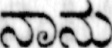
ನಾನು
